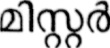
മിസ്റ്റര്‍
